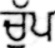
ਚੁੱਪ
